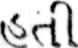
હતી
